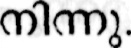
നിന്നു.
